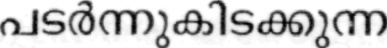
പടര്‍ന്നുകിടക്കുന്ന
